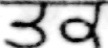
ਤਕ
